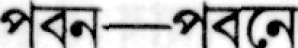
পবন-পবনে
